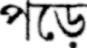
পড়ে
